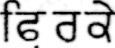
ਫ਼ਿਰਕੇ
